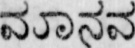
ಮಾನವ
